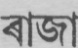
ৰাজা
